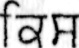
ਕਿਸ
